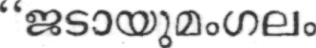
"ജടായുമംഗലം
